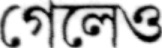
গেলেও
